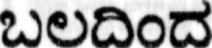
ಬಲದಿಂದ
